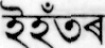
ইহঁতৰ
